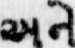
અને
